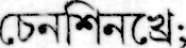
চেনশিনখ্রে;
